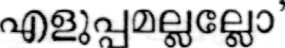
എളുപ്പമല്ലല്ലോ’
